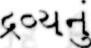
દ્રવ્યનું
